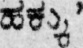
ಹಕ್ಕು’
